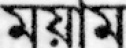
ময়াম
